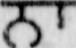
ਨਾ
